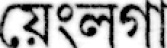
য়েংলগা
